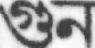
গুন
